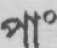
পা
